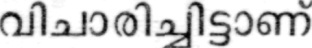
വിചാരിച്ചിട്ടാണ്
